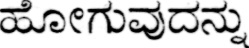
ಹೋಗುವುದನ್ನು
